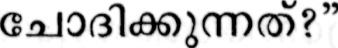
ചോദിക്കുന്നത്?”
